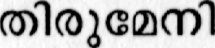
തിരുമേനി
